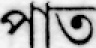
পাত
